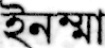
ইনম্মা
